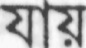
যায়
